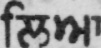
ਲਿਆ
